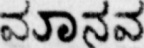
ಮಾನವ
